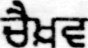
ਚੈਖ਼ਵ
